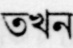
তখন
